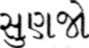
સુણજો
